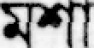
মশা
